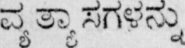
ವ್ಯತ್ಯಾಸಗಳನ್ನು
